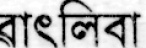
ৱাৎলিবা
